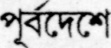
পূর্বদেশে
